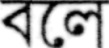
বলে
